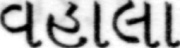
વહાલા
